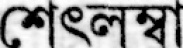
শেৎলম্বা
